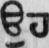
ਉਹ
